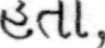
હતા,
